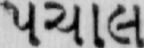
પચાલ
